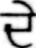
ਦੇ
